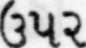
ઉપર
